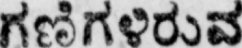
ಗಣಿಗಳಿರುವ
